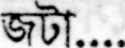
জটা....
